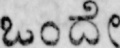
ಒಂದೇ
